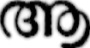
ആ
